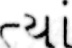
ત્યાં
